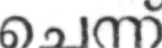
ചെന്ന്
